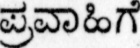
ಪ್ರವಾಹಿಗೆ
